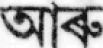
আৰু
